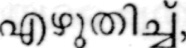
എഴുതിച്ച്,
